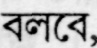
বলবে,
